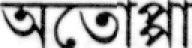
অতোপ্পা
